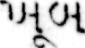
ખૂબ
